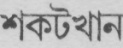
শকটখান
